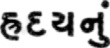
હ્રદયનું
